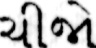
ચીજો
